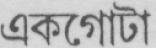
একগোটা
